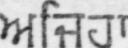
ਅਜਿਹਾ
